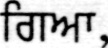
ਗਿਆ,
